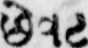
છેવટ
